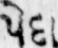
પેદા
